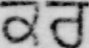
ਕਰ
